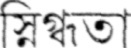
স্নিগ্ধতা
